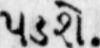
પડશે.
